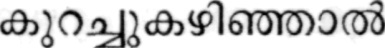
കുറച്ചുകഴിഞ്ഞാല്‍
